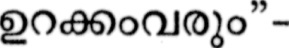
ഉറക്കംവരും”-
